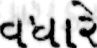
વધારે
